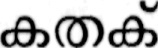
കതക്
